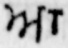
ਆ
